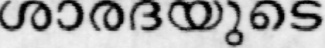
ശാരദയുടെ
